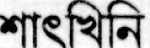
শাৎখিনি
